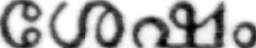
ശേഷം
